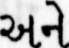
અને
